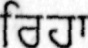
ਰਿਹਾ
